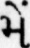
મેં
